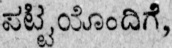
ಪಟ್ಟಿಯೊಂದಿಗೆ,
